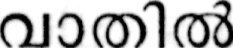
വാതില്‍
